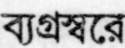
ব্যগ্রস্বরে
